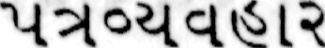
પત્રવ્યવહાર
